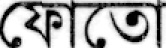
ফোতো
